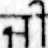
ਜੀ
